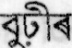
বুঢ়ীৰ
